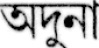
অদুনা
